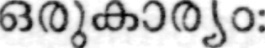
ഒരുകാര്യം:
